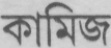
কামিজ
